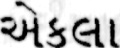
એકલા
